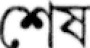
শেষ
